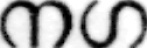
നഗ
